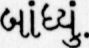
બાંધ્યું.
